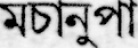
মচানুপা
